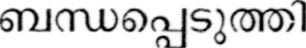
ബന്ധപ്പെടുത്തി
